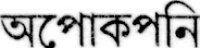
অপোকপনি
